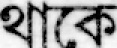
থাকে
